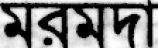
মরমদা
